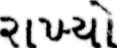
રાખ્યો
